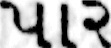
પાર
